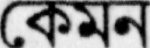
কেমন
